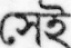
সেই
